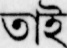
তাই
